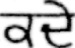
ਕਦੇ
